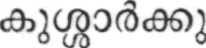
കുശ്ശാര്‍ക്കു
